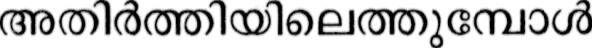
അതിര്‍ത്തിയിലെത്തുമ്പോള്‍
